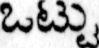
ಒಟ್ಟು
